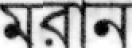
মরান
